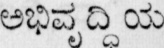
ಅಭಿವೃದ್ಧಿಯ
